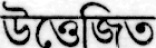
উত্তেজিত
